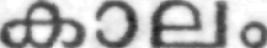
കാലം
